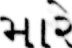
મારે
